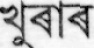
খুৰাৰ
